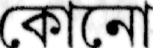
কোনো
